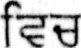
ਵਿਚ
